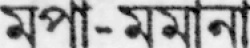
মপা-মমানা
